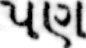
પણ
